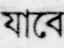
যাবে
